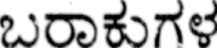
ಬರಾಕುಗಳ
